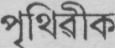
পৃথিৱীক
